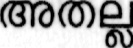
അതല്ല
